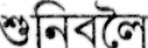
শুনিবলৈ
